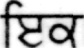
ਇਕ
